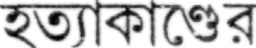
হত্যাকাণ্ডের
